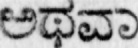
ಅಥವಾ
